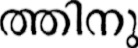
ത്തിനു
